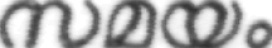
സമയം
